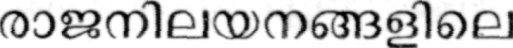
രാജനിലയനങ്ങളിലെ
